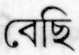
বেছি
